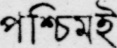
পশ্চিমই
